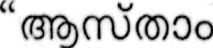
"ആസ്താം
